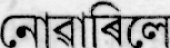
নোৱাৰিলে
